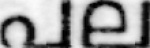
പല
